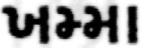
ખમ્મા
